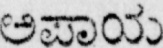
ಅಪಾಯ
